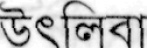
উৎলিবা
